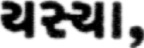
યસ્યા,
